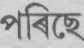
পৰিছে
